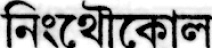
নিংথৌকোল
